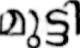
മുട്ടി
